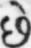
છે
